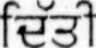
ਦਿੱਤੀ
